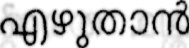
എഴുതാന്‍
